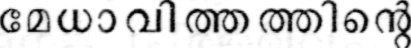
മേധാവിത്തത്തിന്റെ
